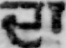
ਦਾ
